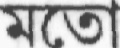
মতো
